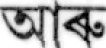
আৰু
